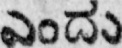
ಎಂದು
